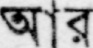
আর
